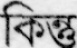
কিন্তু
